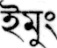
ইমুং
